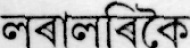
লৰালৰিকৈ
